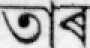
তাৰ
